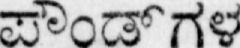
ಪೌಂಡ್‌ಗಳ
